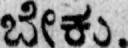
ಬೇಕು.
